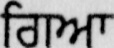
ਗਿਆ
